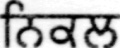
ਨਿਕਲ
